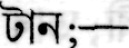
টান;-
